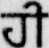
ਹੀ
